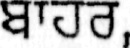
ਬਾਹਰ,
